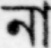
না
